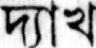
দ্যাখ
